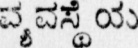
ವ್ಯವಸ್ಥೆಯ
